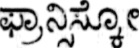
ಫ್ರಾನ್ಸಿಸ್ಕೋ
